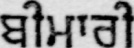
ਬੀਮਾਰੀ
